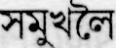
সমুখলৈ
